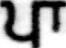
ਪਾ
